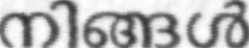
നിങ്ങള്‍
